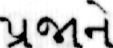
પ્રજાને
